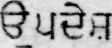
ਉਪਦੇਸ਼
